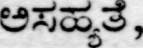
ಅಸಹ್ಯತೆ,
